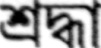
শ্রদ্ধা
